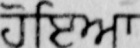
ਹੋਇਆ
